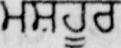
ਮਸ਼ਹੂਰ
